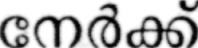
നേര്‍ക്ക്
